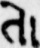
તો
